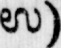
ಉ)
